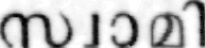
സ്വാമി
